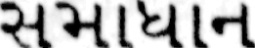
સમાધાન
